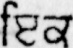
ਇਕ
